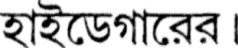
হাইডেগারের।
